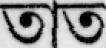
তাত
